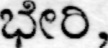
ಭೇರಿ,
